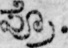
ಪ್ರೊ.
